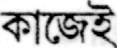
কাজেই
